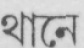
থানে
